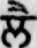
ਲੈ
